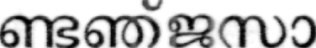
ണ്ടഞ്ജസാ
